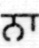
ਨਾ
